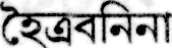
হৈত্রবনিনা
